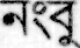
নংবু
